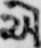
એ
